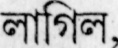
লাগিল,
